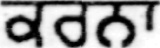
ਕਰਨਾ
